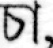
চা,
